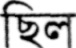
ছিল
